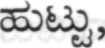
ಹುಟ್ಟು,
